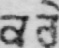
ਕਰੇ
